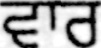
ਵਾਰ
